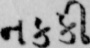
નક્કી
